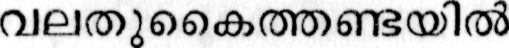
വലതുകൈത്തണ്ടയില്‍
